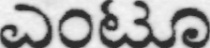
ಎಂಟೂ
